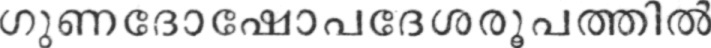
ഗുണദോഷോപദേശരൂപത്തില്‍
